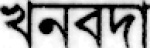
খনবদা
